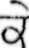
ਕੇ
